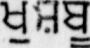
ਖੁਸ਼ਬੂ
